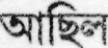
আছিল
